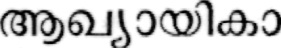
ആഖ്യായികാ
